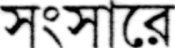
সংসারে
